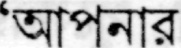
‘আপনার
